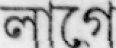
লাগে
